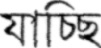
যাচ্ছি
